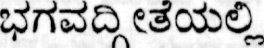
ಭಗವದ್ಗೀತೆಯಲ್ಲಿ
